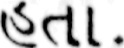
હતા.
